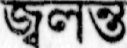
জ্বলন্ত
